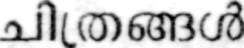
ചിത്രങ്ങള്‍
